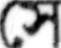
সে
